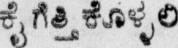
ಕೈಗೆತ್ತಿಕೊಳ್ಳಲಿ
